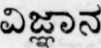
ವಿಜ್ಞಾನ
